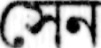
সেন
